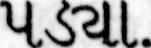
પડ્યા.
